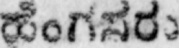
ಹೆಂಗಸರು
